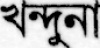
খন্দুনা
